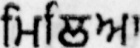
ਮਿਲਿਆ
